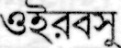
ওইরবসু
